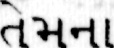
તેમના
